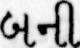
બની
